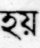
হয়
